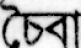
চৈবা
